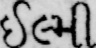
ઈલ્મી
